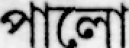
পালো
